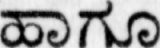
ಹಾಗೂ
